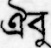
ঐবু
